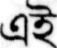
এই
